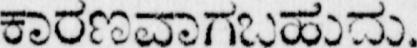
ಕಾರಣವಾಗಬಹುದು.
